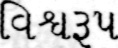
વિશ્વરૂપ
